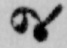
જ
